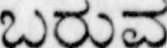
ಬರುವ
